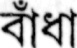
বাঁধা
